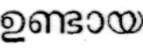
ഉണ്ടായ
